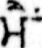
ਮੈਂ
